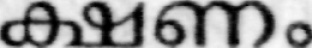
ക്ഷണം
